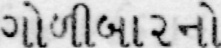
ગોળીબારનો
